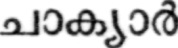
ചാക്യാര്‍
